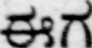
ಈಗ
